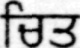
ਚਿਤ
